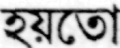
হয়তো
